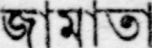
জামাতা
